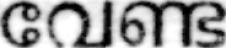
വേണ്ട
